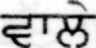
ਵਾਲੇ
